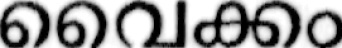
വൈക്കം
